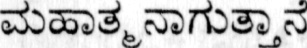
ಮಹಾತ್ಮನಾಗುತ್ತಾನೆ
